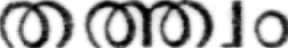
തത്ത്വം
